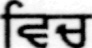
ਵਿਚ
